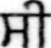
ਸੀ
